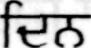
ਦਿਨ
